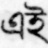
এই
